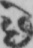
છે
